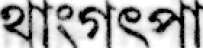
থাংগৎপা
